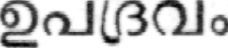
ഉപദ്രവം
